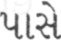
પાસે
